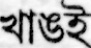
খাঙই
